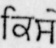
ਕਿਸੇ
